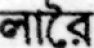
লারৈ
